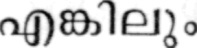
എങ്കിലും
